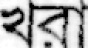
খরা
